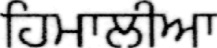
ਹਿਮਾਲੀਆ
